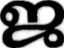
ജ
